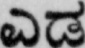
ಎಡ
